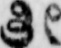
ತೀ.
